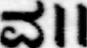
ವ||
